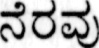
ನೆರವು
